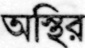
অস্থির
